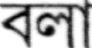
বলা
